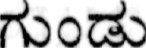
ಗುಂಡು
